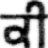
ਕੀ
